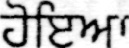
ਹੋਇਆ
